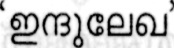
'ഇന്ദുലേഖ'
